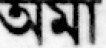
অমা
